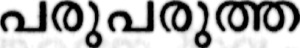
പരുപരുത്ത
